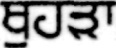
ਥੁਹੜਾ
